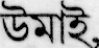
উমাই,
